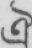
ঐ
